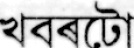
খবৰটো
